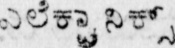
ಎಲೆಕ್ಟ್ರಾನಿಕ್ಸ್
